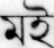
মই
